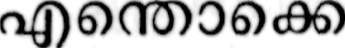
എന്തൊക്കെ
